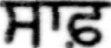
ਸਾਫ਼
